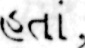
હતાં,
